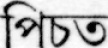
পিচত
